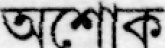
অশোক
